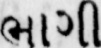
ભાગી
